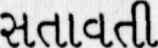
સતાવતી
